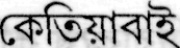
কেতিয়াবাই
